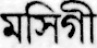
মসিগী
